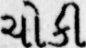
ચોકી
